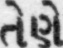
તેણે
